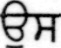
ਉਸ
